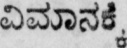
ವಿಮಾನಕ್ಕೆ
